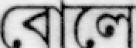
বোলে
